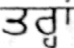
ਤਰ੍ਹਾਂ
